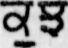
ਕੁਝ
